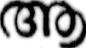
ആ
